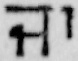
ਜਾ
